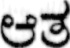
ಆತ
